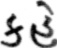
કહે
